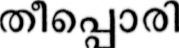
തീപ്പൊരി
